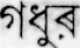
গধুৰ
